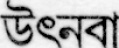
উৎনবা
